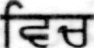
ਵਿਚ
